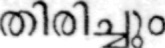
തിരിച്ചും
